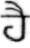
ਹੈ
